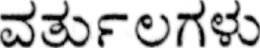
ವರ್ತುಲಗಳು
